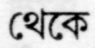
থেকে
